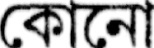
কোনো
